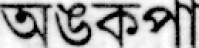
অঙকপা
